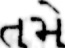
તમે
